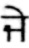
ਜੇ
